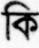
কি
